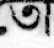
তো
